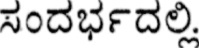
ಸಂದರ್ಭದಲ್ಲಿ.
